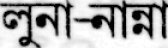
লুনা-নান্না
